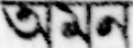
অমন
